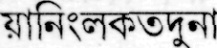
য়ানিংলকতদুনা
